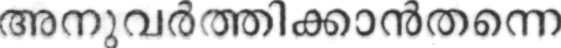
അനുവര്‍ത്തിക്കാന്‍തന്നെ
